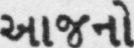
આજનો
